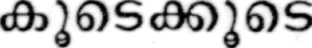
കൂടെക്കൂടെ
